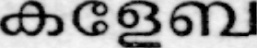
കളേബ
